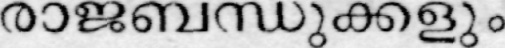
രാജബന്ധുക്കളും
